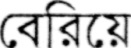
বেরিয়ে
